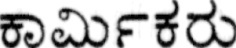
ಕಾರ್ಮಿಕರು
